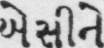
બેસીને
